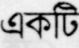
একটি
